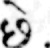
છે.
